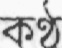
কণ্ঠ
